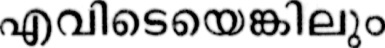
എവിടെയെങ്കിലും
